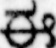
ಈ
